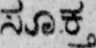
ಸೂಕ್ತ
